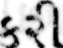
કરી
